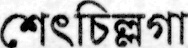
শেৎচিল্লগা
